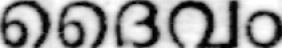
ദൈവം
